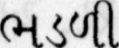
ભડળી
